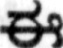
ಈ
